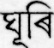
ঘূৰি
